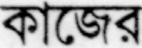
কাজের
